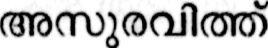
അസുരവിത്ത്
